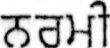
ਨਰਮੀ
